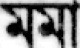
মমা
